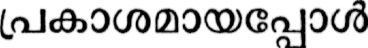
പ്രകാശമായപ്പോള്‍
